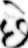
છે
